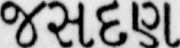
જસદણ
